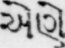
એણે
